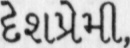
દેશપ્રેમી,
